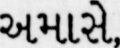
અમાસે,
